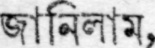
জানিলাম,
